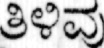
ತಿಳಿವು
